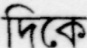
দিকে
